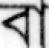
বা
